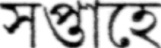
সপ্তাহে
